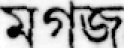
মগজ
